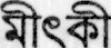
মীৎকী
